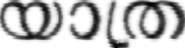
യാത്ര
